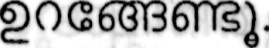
ഉറങ്ങേണ്ടൂ.
